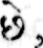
છે,
